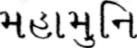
મહામુનિ
